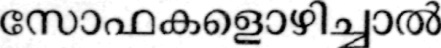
സോഫകളൊഴിച്ചാല്‍
